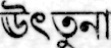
ঊৎতুনা
